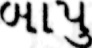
બાપુ
